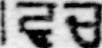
ਵਿਚ
